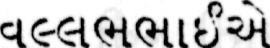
વલ્લભભાઈએ
